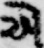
એ
